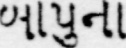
બાપુના
